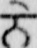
ਨੇ
